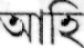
আহি
